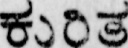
ಕುರಿತ
